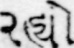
રહ્યો
